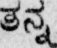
ತನ್ನ
